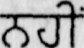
ਨਹੀਂ
